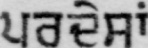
ਪਰਦੇਸਾਂ
